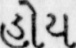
હોય
